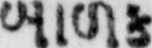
બાળક
